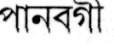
পানবগী
